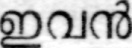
ഇവന്‍
